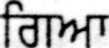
ਗਿਆ
